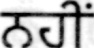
ਨਹੀਂ
